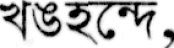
খঙহন্দে,
